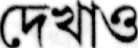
দেখাও
